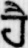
ਹੈ
